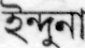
ইন্দুনা
